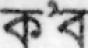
ক'ব
